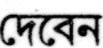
দেবেন
